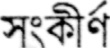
সংকীর্ণ
